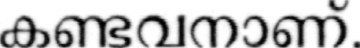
കണ്ടവനാണ്.
